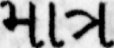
માત્ર
